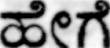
ಹೇಗೆ
